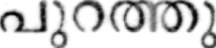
പുറത്തു
